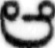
ಆ
